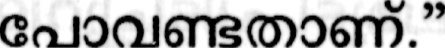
പോവണ്ടതാണ്."
